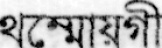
থম্মোয়গী
